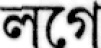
লগে
